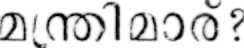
മന്ത്രിമാര്?
